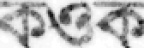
কওক
